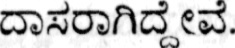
ದಾಸರಾಗಿದ್ದೇವೆ.
